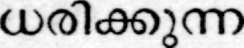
ധരിക്കുന്ന
